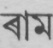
ৰাম
